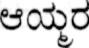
ಆಯ್ಮರ
